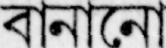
বানানো
